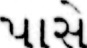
પાસે
